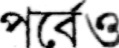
পর্বেও
